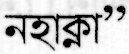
নহাক্না”
